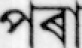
পৰা
